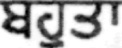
ਬਹੁਤਾ
